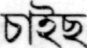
চাইছ
